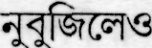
নুবুজিলেও
